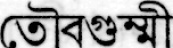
তৌবগুম্মী
